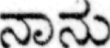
ನಾನು
